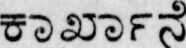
ಕಾರ್ಖಾನೆ
